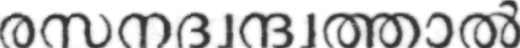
രസനദ്വന്ദ്വത്താല്‍
